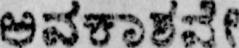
ಅವಕಾಶವೇ
